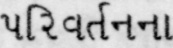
પરિવર્તનના
